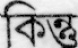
কিন্তু
